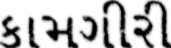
કામગીરી
